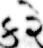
કરે
